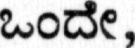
ಒಂದೇ,
